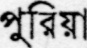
পুরিয়া
